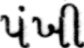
પંખી
